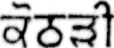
ਕੋਠੜੀ
